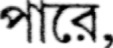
পারে,
